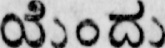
ಯೆಂದು
